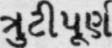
ત્રુટીપૂર્ણ
